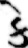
કે
